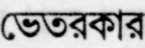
ভেতরকার
